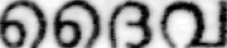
ദൈവ
